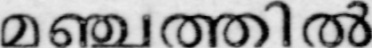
മഞ്ചത്തില്‍
